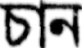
চান
